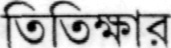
তিতিক্ষার
